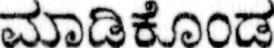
ಮಾಡಿಕೊಂಡ
